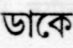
ডাকে
